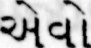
એવો
